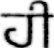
ਹੀ
